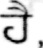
ਹੈ,
